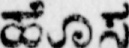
ಹೊಸ
